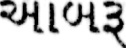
આબરૂ
